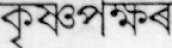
কৃষ্ণপক্ষৰ
